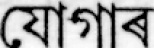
যোগাৰ
